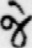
જે
